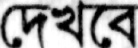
দেখবে
